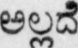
ಅಲ್ಲದೆ
